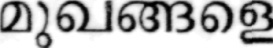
മുഖങ്ങളെ
